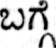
ಬಗ್ಗೆ
